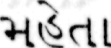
મહેતા
